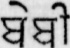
ਬੇਬੀ
